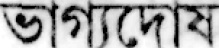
ভাগ্যদোষ
